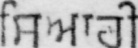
ਸਿਆਹੀ
